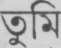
তুমি
